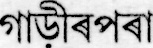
গাড়ীৰপৰা
